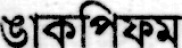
ঙাকপিফম
